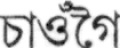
চাওঁগৈ
